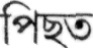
পিছত
